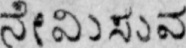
ನೇಮಿಸುವ
